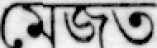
মেজত
